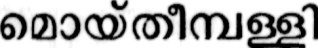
മൊയ്തീമ്പള്ളി
